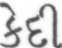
કેદી
